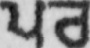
ਪਰ
